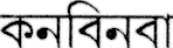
কনবিনবা
